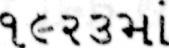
૧૯૨૩માં
